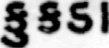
કુકડા
